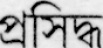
প্রসিদ্ধ
